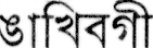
ঙাখিবগী
